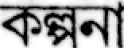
কল্পনা
